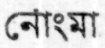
নোংমা
